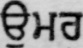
ਉਮਰ
